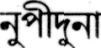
নুপীদুনা
